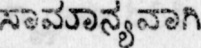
ಸಾಮಾನ್ಯವಾಗಿ
